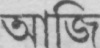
আজি
